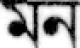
মন
